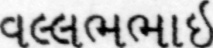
વલ્લભભાઈ
